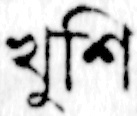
খুশি
